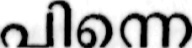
പിന്നെ
